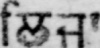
ਲਿਜਾ
